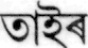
তাইৰ
